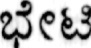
ಭೇಟಿ
